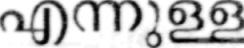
എന്നുള്ള
